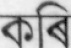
কৰি
